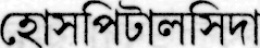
হোসপিটালসিদা
